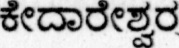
ಕೇದಾರೇಶ್ವರ
